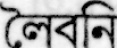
লৈবনি
